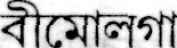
বীমোলগা
